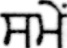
ਸਮੇਂ
